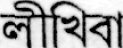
লীখিবা
